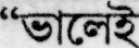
"ভালেই
